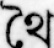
থৈ
